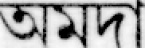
অমদা
